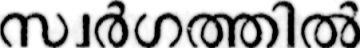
സ്വര്‍ഗത്തില്‍
